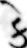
કે
